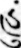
હું
